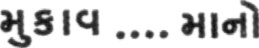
મુકાવ................માનો
